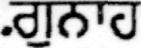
ਗ਼ਨਾਹ
